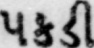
પકડી
